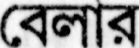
বেলার
